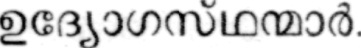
ഉദ്യോഗസ്ഥന്മാര്‍.
